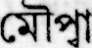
মৌপ্বা
